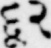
દૂર
